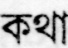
কথা
